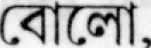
বোলো,
